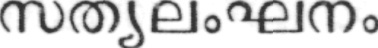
സത്യലംഘനം
